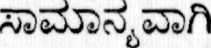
ಸಾಮಾನ್ಯವಾಗಿ
